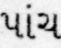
પાંચ
